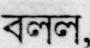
বলল,
